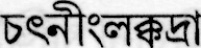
চৎনীংলক্কদ্রা
